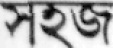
সহজ
